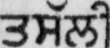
ਤਸੱਲੀ
